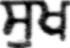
ਸੁਖ
